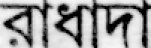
রাধাদা
